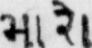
મારો
